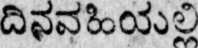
ದಿವವಹಿಯಲ್ಲಿ
